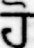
ਹੋ
